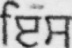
ਇਸ
